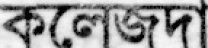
কলেজদা
